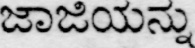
ಜಾಜಿಯನ್ನು
